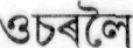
ওচৰলৈ
